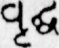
વૃદ્ધ
